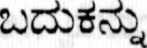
ಬದುಕನ್ನು
